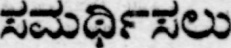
ಸಮರ್ಥಿಸಲು
